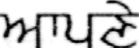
ਆਪਣੇ
